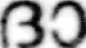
ദാ
